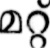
മറ്റ്
